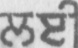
ਲਈ
